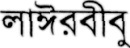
লাঈরবীবু
